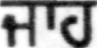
ਜਾਹ
